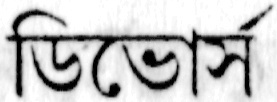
ডিভোর্স
